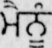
ਮੈਨੂੰ
